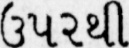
ઉપરથી
